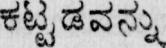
ಕಟ್ಟಡವನ್ನು
